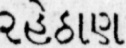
રહેઠાણ
